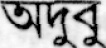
অদুবু
